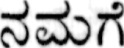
ನಮಗೆ
